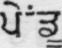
ਪੇਂਡੂ
